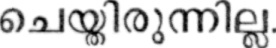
ചെയ്തിരുന്നില്ല.
